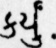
કર્યું.
